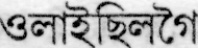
ওলাইছিলগৈ
